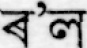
ৰ'ল
